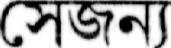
সেজন্য
